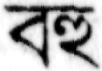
বহু
